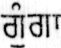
ਗੁੰਗਾ
